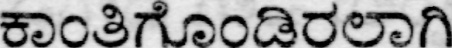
ಕಾಂತಿಗೊಂಡಿರಲಾಗಿ
